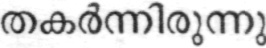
തകര്‍ന്നിരുന്നു
